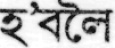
হ'বলৈ
